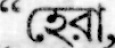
“হেরা,
